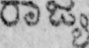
ರಾಜ್ಯ
